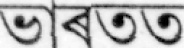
ভাৰতত
